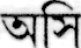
অসি
